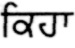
ਕਿਹਾ
